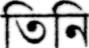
তিনি
